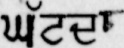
ਘੱਟਦਾ
